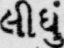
લીધું
